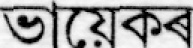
ভায়েকৰ
